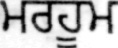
ਮਰਹੂਮ
